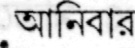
আনিবার
